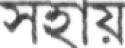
সহায়
